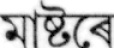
মাষ্টৰে
